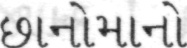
છાનોમાનો
